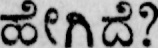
ಹೇಗಿದೆ?
